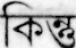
কিন্তু
